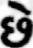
છે
